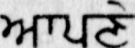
ਆਪਣੇ
